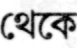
থেকে
